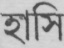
হাসি
